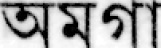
অমগা
